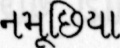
નમૂછિયા
